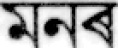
মনৰ
